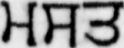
ਮਸਤ
